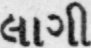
લાગી
